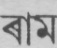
ৰাম
